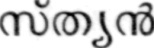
സ്ത്യന്‍
